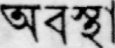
অবস্থা
